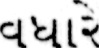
વધારે
